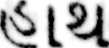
હાથ
